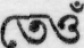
তেওঁ
